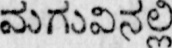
ಮಗುವಿನಲ್ಲಿ
